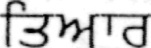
ਤਿਆਰ
